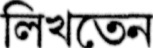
লিখতেন
